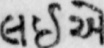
લઈએ
